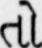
તો
